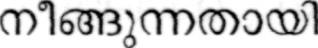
നീങ്ങുന്നതായി
